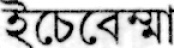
ইচেবেম্মা
